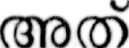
അത്
